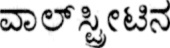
ವಾಲ್ ಸ್ಟ್ರೀಟಿನ
